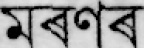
মৰণৰ
